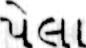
પેલા
